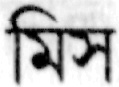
মিস
